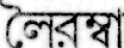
লৈরম্বা
